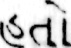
હતો
